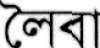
লৈবা
